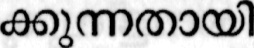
ക്കുന്നതായി
